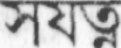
সযত্ন
